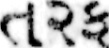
તરફ
